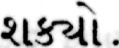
શક્યો.
